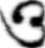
ও
